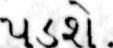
પડશે.
